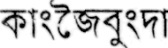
কাংজৈবুংদা
